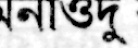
মনাওদু
